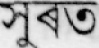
সুৰত
